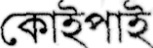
কোইপাই
